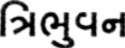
ત્રિભુવન
